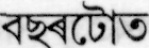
বছৰটোত
